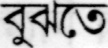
বুঝতে
